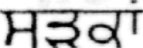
ਸੜਕਾਂ
